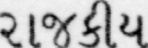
રાજકીય
